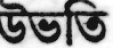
উভতি
